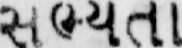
સભ્યતા
